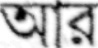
আর
